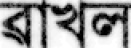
ৱাখল
